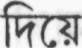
দিয়ে
